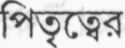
পিতৃত্বের
